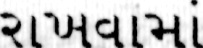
રાખવામાં
